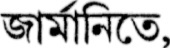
জার্মানিতে,
